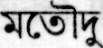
মতৌদু
